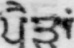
ਪੈੜਾਂ
